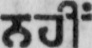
ਨਹੀਂ
